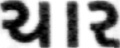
ચાર
